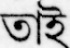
তাই
